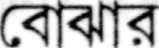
বোঝার
